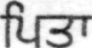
ਪਿਤਾ
